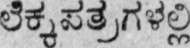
ಲೆಕ್ಕಪತ್ರಗಳಲ್ಲಿ
